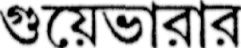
গুয়েভারার
